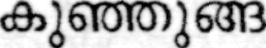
കുഞ്ഞുങ്ങ
